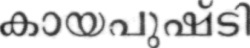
കായപുഷ്ടി
